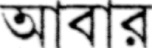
আবার
